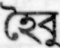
হৈবু
